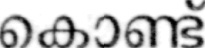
കൊണ്ട്
